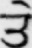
ਤੇ
